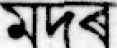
মদৰ
